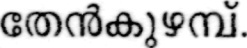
തേന്‍കുഴമ്പ്.
